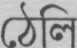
ঠেলি
